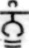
ਨੂੰ
